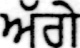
ਅੱਗੇ
